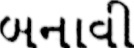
બનાવી
